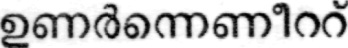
ഉണര്‍ന്നെണീററ്
